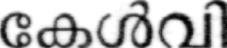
കേള്‍വി
